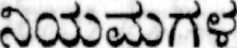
ನಿಯಮಗಳ
